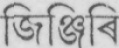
জিঞ্জিৰি
